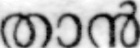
താന്‍
